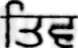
ਤਿਵ
